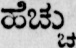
ಹೆಚ್ಚು
